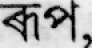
ৰূপ,
